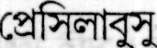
প্রেসিলাবুসু
